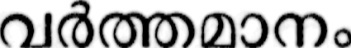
വര്‍ത്തമാനം
